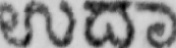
ಉದಾ
